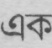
এক
